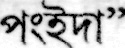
পংইদা”
